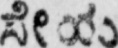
ಸೇಯ
